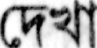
দেখা
